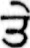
ਤੇ
